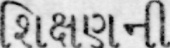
શિક્ષણની
